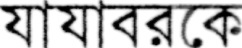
যাযাবরকে
